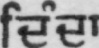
ਦਿੰਦਾ
